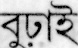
বুঢ়াই
